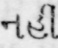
નહીં
